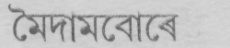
মৈদামবোৰে
